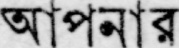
আপনার
